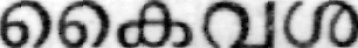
കൈവശ
